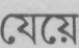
যেয়ে
